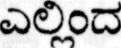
ಎಲ್ಲಿಂದ
